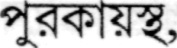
পুরকায়স্থ,
